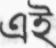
এই
